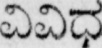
ವಿವಿಧ
